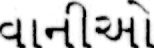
વાનીઓ
